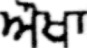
ਔਖਾ
